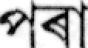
পৰা
